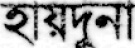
হায়দুনা
